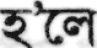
হ'লে
